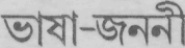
ভাষা-জননী
